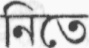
নিতে
